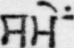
ਸਮੇਂ
